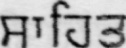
ਸਾਹਿਤ
